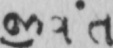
જીવંત
